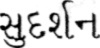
સુદર્શન
